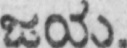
ಜಯ.
